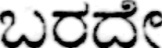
ಬರದೇ
